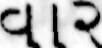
વાર
